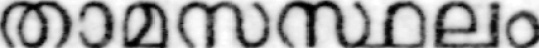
താമസസ്ഥലം
